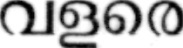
വളരെ
